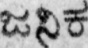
ಜನಿಕ
